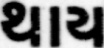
થાય
